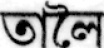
তালৈ
